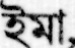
ইমা,
